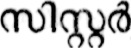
സിസ്റ്റര്‍
